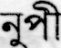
নুপী
